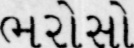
ભરોસો
